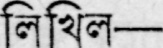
লিখিল—
